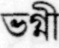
ভগ্নী
